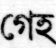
গেহ
